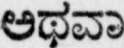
ಅಥವಾ
